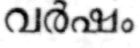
വര്‍ഷം
